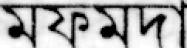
মফমদা
